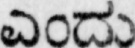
ಎಂದು
